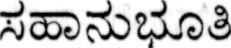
ಸಹಾನುಭೂತಿ
